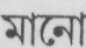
মানো
